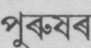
পুৰুষৰ
